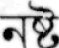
নষ্ট
